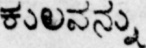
ಕುಲವನ್ನು
